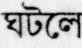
ঘটলে
